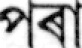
পৰা
